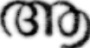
ആ
